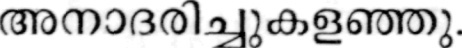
അനാദരിച്ചുകളഞ്ഞു.
